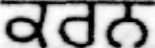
ਕਰਨ
